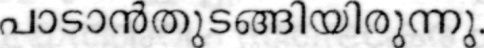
പാടാന്‍തുടങ്ങിയിരുന്നു.
